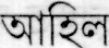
আহিল
